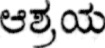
ಆಶ್ರಯ
